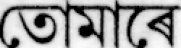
তোমাৰে
